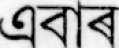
এবাৰ
